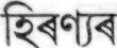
হিৰণ্যৰ
